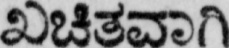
ಖಚಿತವಾಗಿ
